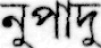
নুপাদু
